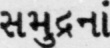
સમુદ્રનાં
